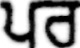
ਪਰ
